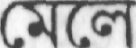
মেলে
